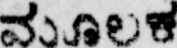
ಮೂಲಕ
